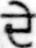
ਦੇ
